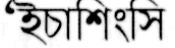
“ইচাশিংসি
